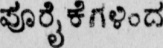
ಪೂರೈಕೆಗಳಿಂದ
